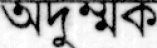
অদুম্মক
